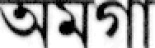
অমগা
